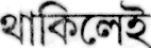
থাকিলেই
